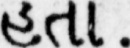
હતા.
